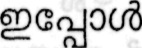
ഇപ്പോള്‍
